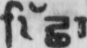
ਪਿੱਛਾ
